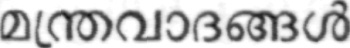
മന്ത്രവാദങ്ങള്‍
